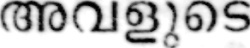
അവളുടെ
